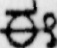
ಈ
